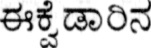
ಈಕ್ವೆಡಾರಿನ
